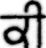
ਕੀ
